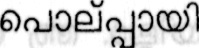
പൊല്പ്പായി
